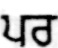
ਪਰ
